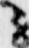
કે
